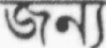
জন্য
